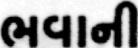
ભવાની
